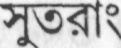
সুতরাং
